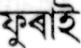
ফুৰাই
